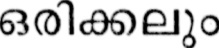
ഒരിക്കലും
